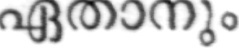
ഏതാനും
